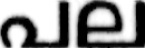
പല
